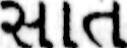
સાત
